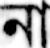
না
